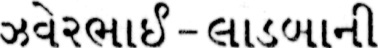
ઝવેરભાઈ-લાડબાની
